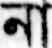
না
